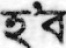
হ'ব
